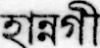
হান্নগী
